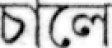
চালে
